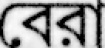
বেরা
